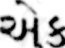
એક
